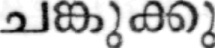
ചങ്കുക്കു
